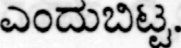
ಎಂದುಬಿಟ್ಟ.
